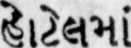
હોટેલમાં
